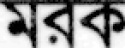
মরক
